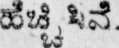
ಹೆಚ್ಚಿಸಿವೆ.
